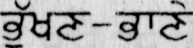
ਭੁੱਖਣ-ਭਾਣੇ
